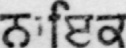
ਨਾਇਕ
